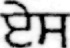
ਏਸ
